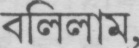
বলিলাম,
